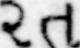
રત
